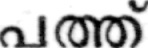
പത്ത്
